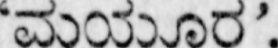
‘ಮಯೂರ’.
